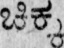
ಚಿಕ್ಕ
